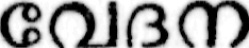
വേദന
